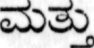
ಮತ್ತು
